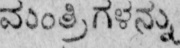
ಮಂತ್ರಿಗಳನ್ನು
